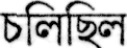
চলিছিল
